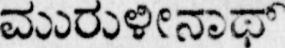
ಮುರಳೀನಾಥ್
